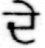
ਦੇ
